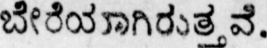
ಬೇರೆಯಾಗಿರುತ್ತವೆ.
